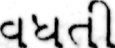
વધતી
